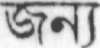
জন্য
